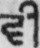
ਵੀ
